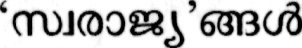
‘സ്വരാജ്യ’ങ്ങള്‍
